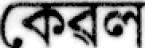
কেৱল
